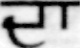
ਦਾ
